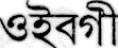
ওইবগী
